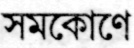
সমকোণে
